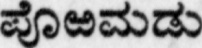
ಪೊಱಮಡು
